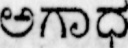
ಅಗಾಧ
